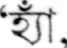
‘হ্যাঁ,
